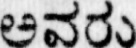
ಅವರು
